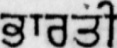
ਭਾਰਤੀ
